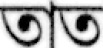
তাত
